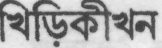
খিড়িকীখন
